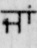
ਜਾਂ
